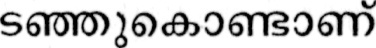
ടഞ്ഞുകൊണ്ടാണ്
